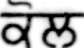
ਕੋਲ
